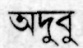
অদুবু
